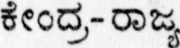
ಕೇಂದ್ರ-ರಾಜ್ಯ
